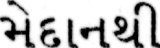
મેદાનથી
